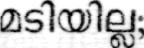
മടിയില്ല;
